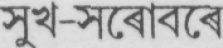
সুখ-সৰোবৰে
